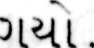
ગયો.
